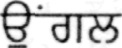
ਉਂਗਲ
